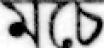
মচে
